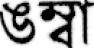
ঙম্বা
